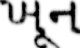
ખૂન
